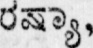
ರಷ್ಯಾ,
